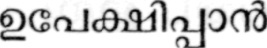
ഉപേക്ഷിപ്പാന്‍
